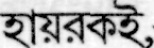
হায়রকই,
